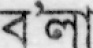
ব'লা
